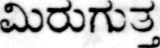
ಮಿರುಗುತ್ತ
